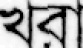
খরা
